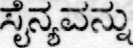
ಸೈನ್ಯವನ್ನು
